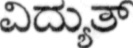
ವಿದ್ಯುತ್
